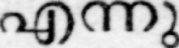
എന്നു
